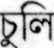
চুলি
